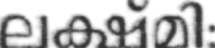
ലക്ഷ്മി:
